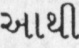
આથી
